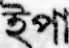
ইপা
